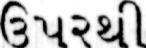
ઉપરથી
